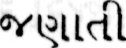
જણાવી
